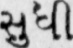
સુધી
